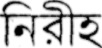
নিরীহ
